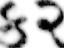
કર
